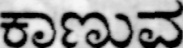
ಕಾಣುವ
